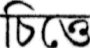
চিত্তে
